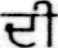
ਦੀ
